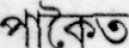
পাকৈত
